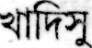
খাদিসু
